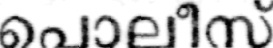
പൊലീസ്
